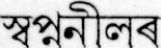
স্বপ্ননীলৰ
